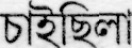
চাইছিলা
